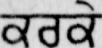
ਕਰਕੇ
